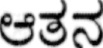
ಆತನ
